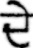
ਦੇ
